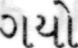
ગયો
